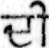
ਦੀ
